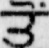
ਤੋਂ
